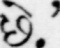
છે.'
